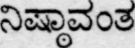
ನಿಷ್ಠಾವಂತ
